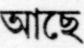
আছে
